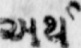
અર્થ
